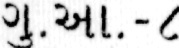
ગુ.આ.-૮
